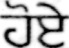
ਹੋਏ
